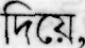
দিয়ে,
